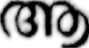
ആ
